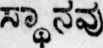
ಸ್ಥಾನವು
